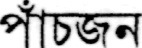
পাঁচজন
